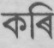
কৰি
